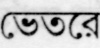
ভেতরে
